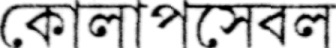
কোলাপসেবল
